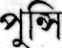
পুন্সি
